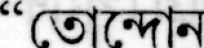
“তোন্দোন
